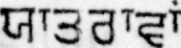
ਯਾਤਰਾਵਾਂ
